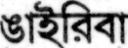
ঙাইরিবা
